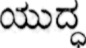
ಯುದ್ಧ
